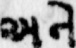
અને
